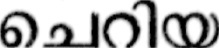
ചെറിയ
